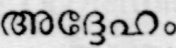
അദ്ദേഹം
